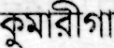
কুমারীগা
